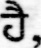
ਹੈ,
